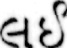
લઈ
